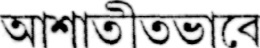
আশাতীতভাবে
